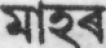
মাহৰ
